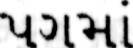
પગમાં
